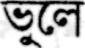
ভুলে
